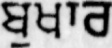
ਬੁਖਾਰ
